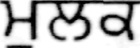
ਮੁਲਕ
